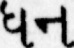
ધન
